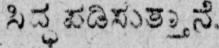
ಸಿದ್ಧಪಡಿಸುತ್ತಾನೆ.
